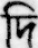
দি
